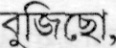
বুজিছো,
